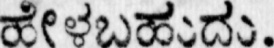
ಹೇಳಬಹುದು.
